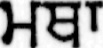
ਮਥਾ
